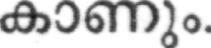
കാണും.
